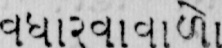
વધારવાવાળો
